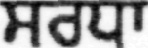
ਸਰਧਾ
